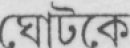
ঘোটকে
